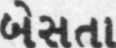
બેસતા
